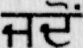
ਜਦੋਂ
